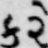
કરે
